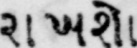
રાખશો
